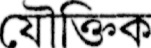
যৌক্তিক
